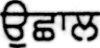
ਉਛਾਲ
